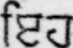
ਇਹ
